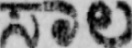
ಸಾಲ
